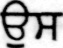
ਉਸ
